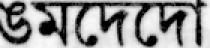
ঙমদেদো
